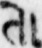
તો
